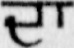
ਦਾ
